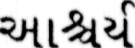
આશ્ચર્ય
